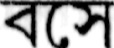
বসে
